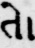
તો
